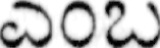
ಎಂಬ
